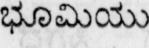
ಭೂಮಿಯು
